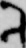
ને
